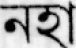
নহা
